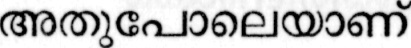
അതുപോലെയാണ്
